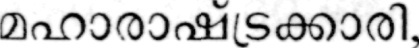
മഹാരാഷ്ട്രക്കാരി,
